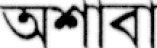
অশাবা
